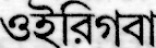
ওইরিগবা
